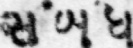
સંબંધ
